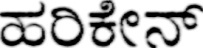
ಹರಿಕೇನ್
